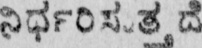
ನಿರ್ಧರಿಸುತ್ತದೆ
